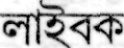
লাইবক
